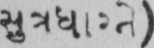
સુત્રધારને)
